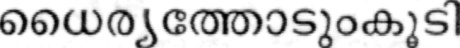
ധൈര്യത്തോടുംകൂടി
